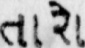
તારો
